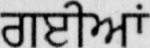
ਗਈਆਂ
